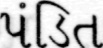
પંડિત
